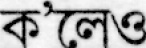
ক'লেও
